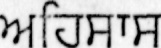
ਅਹਿਸਾਸ
